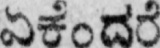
ಏಕೆಂದರೆ
